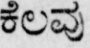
ಕೆಲವು
